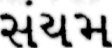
સંયમ
